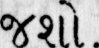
જશો.
